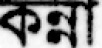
কন্না
